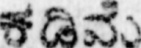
ಕಡಿಮೆ
